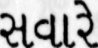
સવારે
